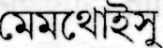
মেমথোইসু
